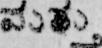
ಮತ್ತು
